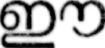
ഈ
